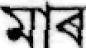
মাৰ
